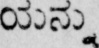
ಯನ್ನು
